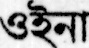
ওইনা
